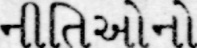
નીતિઓનો
